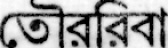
তৌররিবা
